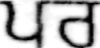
ਪਰ
